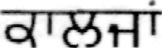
ਕਾਲਜਾਂ
